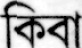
কিবা
